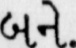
બને.
